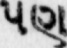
પણ
